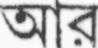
আর
